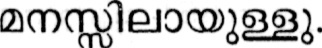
മനസ്സിലായുള്ളു.
